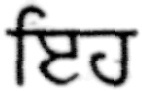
ਇਹ
